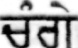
ਚੰਗੇ
